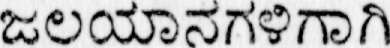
ಜಲಯಾನಗಳಿಗಾಗಿ
